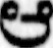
ಆ
